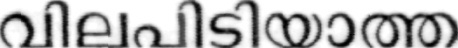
വിലപിടിയാത്ത
